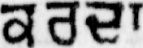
ਕਰਦਾ
